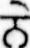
ਨੇ
